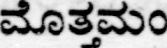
ಮೊತ್ತಮಂ
